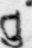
તું
